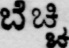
ಬೆಚ್ಚಿ
